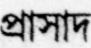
প্রাসাদ
